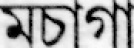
মচাগা
